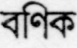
বণিক
